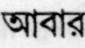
আবার
